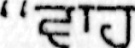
''ਵਾਹ
